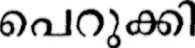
പെറുക്കി
